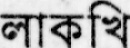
লাকখি
